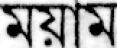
ময়াম
